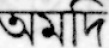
অমদি
